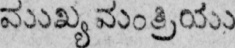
ಮುಖ್ಯಮಂತ್ರಿಯು
